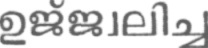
ഉജ്ജ്വലിച്ച
